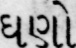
ઘણો
